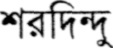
শরদিন্দু
